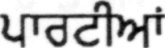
ਪਾਰਟੀਆਂ
